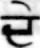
ਦੇ
